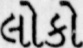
લોકો
